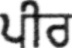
ਪੀਰ
